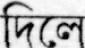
দিলে
